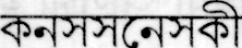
কনসসনেসকী
